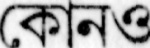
কোনও
